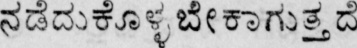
ನಡೆದುಕೊಳ್ಳಬೇಕಾಗುತ್ತದೆ
